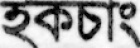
হকচাং
